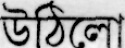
উঠিলো
